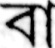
বা
